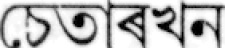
চেতাৰখন
